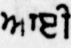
ਆਈ
